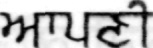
ਆਪਣੀ
